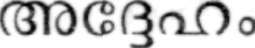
അദ്ദേഹം
